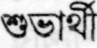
শুভার্থী
